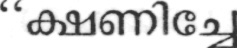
"ക്ഷണിച്ചേ
